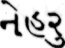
નેહરુ
